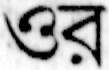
ওর
